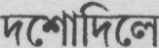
দশোদিলে
